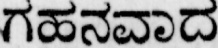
ಗಹನವಾದ
